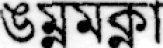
ঙম্নমক্না
